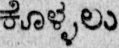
ಕೊಳ್ಳಲು
